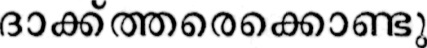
ദാക്ക്ത്തരെക്കൊണ്ടു
